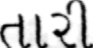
તારી
